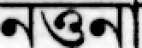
নত্তনা
